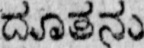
ದೂತನು
